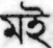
মই
